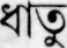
ধাতু
